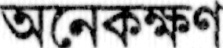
অনেকক্ষণ
